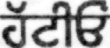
ਹੱਟੀਓਂ
